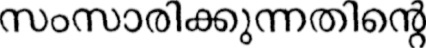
സംസാരിക്കുന്നതിന്റെ
